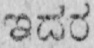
ಇದರ
